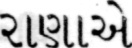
રાણાએ
